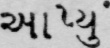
આપ્યું
